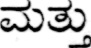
ಮತ್ತು
